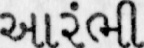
આરંભી
